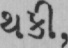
થકી,
